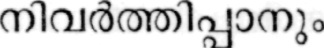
നിവര്‍ത്തിപ്പാനും
